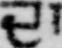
ਦਾ
